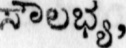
ಸೌಲಭ್ಯ,
